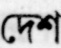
দেশ
